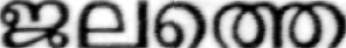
ജലത്തെ
